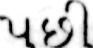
પછી
